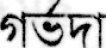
ভর্গদা
